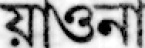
য়াওনা
